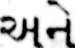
અને
